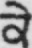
ਕੇ
